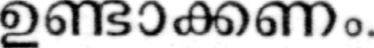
ഉണ്ടാക്കണം.
